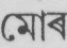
মোৰ
